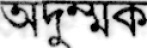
অদুম্মক
